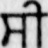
ਸੀ
